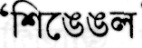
‘শিঙেঙল
